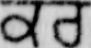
ਕਰ
